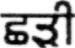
ਛੜੀ
